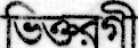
ভিক্তরগী
